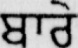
ਬਾਰੇ
